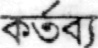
কর্তব্য
